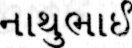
નાથુભાઈ
